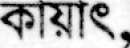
কায়াৎ,
